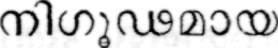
നിഗൂഢമായ
